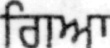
ਗਿਆ
